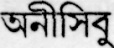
অনীসিবু
